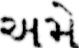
અમે
